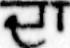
ਦਾ
